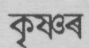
কৃষ্ণৰ
